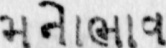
મનોભાવ
